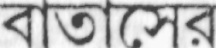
বাতাসের
